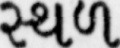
સ્થળ
